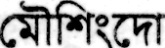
মৌশিংদো
